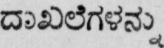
ದಾಖಲೆಗಳನ್ನು
